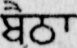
ਬੈਠਾ
